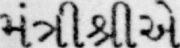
મંત્રીશ્રીએ
